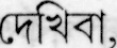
দেখিবা,
